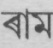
ৰাম
